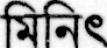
মিনিৎ
